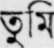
তুমি
